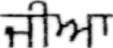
ਜੀਆ
